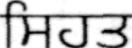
ਸਿਹਤ
